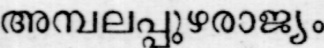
അമ്പലപ്പുഴരാജ്യം
